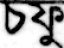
চফু
